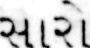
સારો
